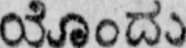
ಯೊಂದು
